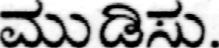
ಮುಡಿಸು.
